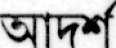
আদর্শ
